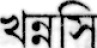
খন্নসি
